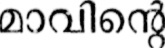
മാവിന്റെ
